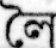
লৈ
